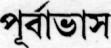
পূর্বাভাস
